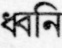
ধ্বনি
